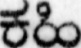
ಕಹಿ
